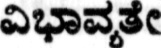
ವಿಭಾವ್ಯತೇ
